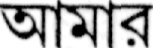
আমার
